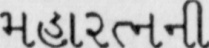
મહારત્નની
